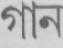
গান
